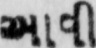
આવી
